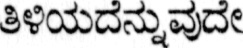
ತಿಳಿಯದೆನ್ನುವುದೇ
